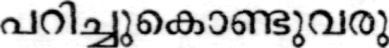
പറിച്ചുകൊണ്ടുവരു
